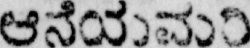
ಆನೆಯಮರಿ
